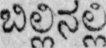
ಬಿಲ್ಲಿನಲ್ಲಿ
